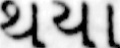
થયા
